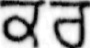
ਕਰ
